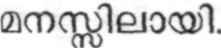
മനസ്സിലായി.
